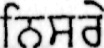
ਨਿਸਰੇ
